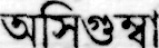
অসিগুম্বা
